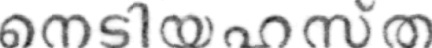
നെടിയഹസ്ത
